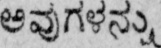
ಅವುಗಳನ್ನು
